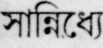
সান্নিধ্যে
